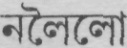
নলৈলো
